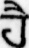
ਹੈ
